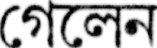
গেলেন
